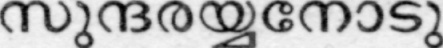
സുന്ദരയ്യനോടു
